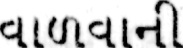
વાળવાની
